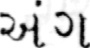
અંગ
